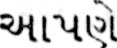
આપણે
